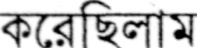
করেছিলাম
